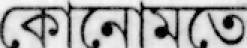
কোনোমতে
